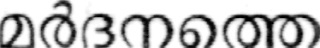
മര്‍ദനത്തെ
